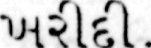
ખરીદી.
